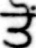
ਤੋਂ
